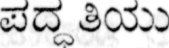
ಪದ್ಧತಿಯು
